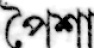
পৈশা
